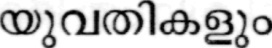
യുവതികളും
